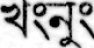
খংনুং
